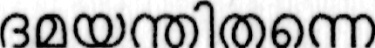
ദമയന്തിതന്നെ
